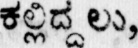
ಕಲ್ಲಿದ್ದಲು,
